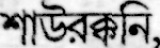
শাউরক্কনি,
